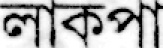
লাকপা
